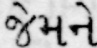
જેમને
